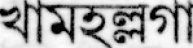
খামহল্লগা
